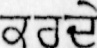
ਕਰਦੇ
